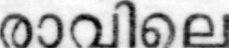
രാവിലെ
